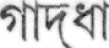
গাদধা
